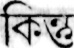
কিন্তু
